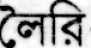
লৈরি
